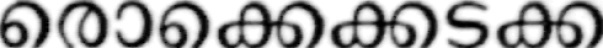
രൊക്കെക്കടക്ക
